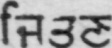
ਜਿਤਣ
